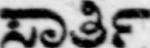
ಸಾರ್ತಿ
